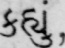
કહ્યું,
